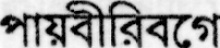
পায়বীরিবগে
